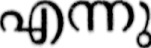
എന്നു
